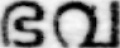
ഭവ
